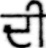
ਦੀ
